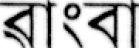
ৱাংবা
